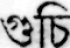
গুচি
